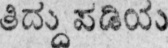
ತಿದ್ದುಪಡಿಯ
